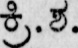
ಕ್ರಿ.ಶ.
